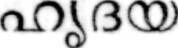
ഹൃദയ
